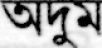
অদুম
